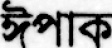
ঈপাক
